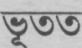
ভূতত
